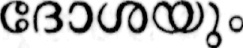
ദോശയും
